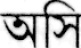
অসি
